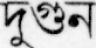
দুগুন
